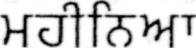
ਮਹੀਨਿਆ
